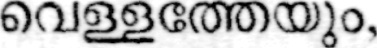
വെള്ളത്തേയും,
